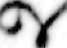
જ
